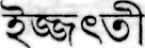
ইজ্জৎতী
